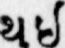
થઈ
